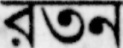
রতন
